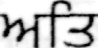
ਅਤਿ
